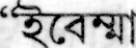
“ইবেম্মা
